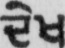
ਦੇਖ
